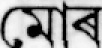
মোৰ
